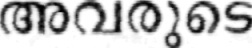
അവരുടെ
